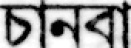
চানবা
